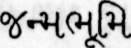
જન્મભૂમિ
